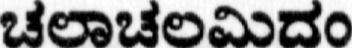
ಚಲಾಚಲಮಿದಂ
